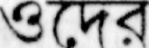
ওদের
